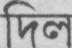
দিল
